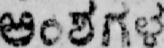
ಅಂಶಗಳ
